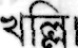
খল্লি।
